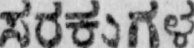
ಸರಕುಗಳ
